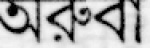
অরুবা
